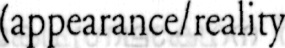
(appearance/reality
